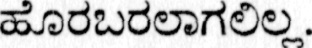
ಹೊರಬರಲಾಗಲಿಲ್ಲ.
